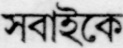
সবাইকে
